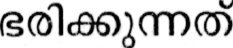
ഭരിക്കുന്നത്
